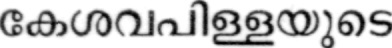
കേശവപിള്ളയുടെ
